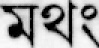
মথং
